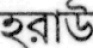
হরাউ
